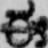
ಈ
